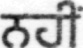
ਨਹੀਂ
